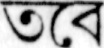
তবে
